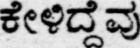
ಕೇಳಿದ್ದೆವು
